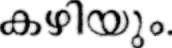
കഴിയും.
